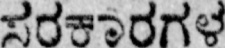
ಸರಕಾರಗಳ
